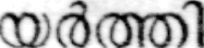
യര്‍ത്തി
